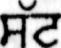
ਸੱਟ
